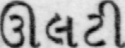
ઊલટી
